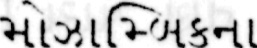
મોઝામ્બિકના
